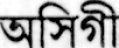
অসিগী
